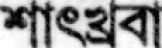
শাৎখ্রবা
